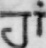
ਹਾਂ
